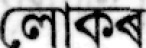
লোকৰ
